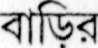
বাড়ির
